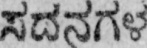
ಸದನಗಳ
